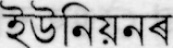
ইউনিয়নৰ
